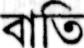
বাতি
